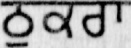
ਠੁਕਰਾ
